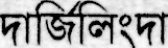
দার্জিলিংদা
